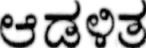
ಆಡಳಿತ
